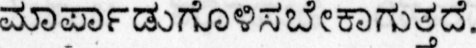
ಮಾರ್ಪಾಡುಗೊಳಿಸಬೇಕಾಗುತ್ತದೆ.
